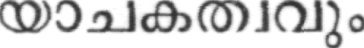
യാചകത്വവും
